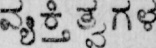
ವ್ಯಕ್ತಿತ್ವಗಳ
